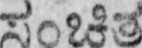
ಸಂಚಿತ
